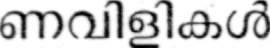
ണവിളികള്‍
